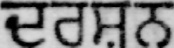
ਦਰਸ਼ਨ
